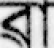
ৱা
